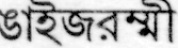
ঙাইজরম্মী
